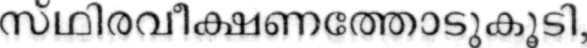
സ്ഥിരവീക്ഷണത്തോടുകൂടി,
